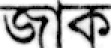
জাক
